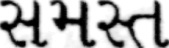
સમસ્ત
